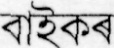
বাইকৰ
